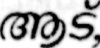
ആട്,
